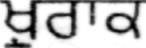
ਖ਼ੁਰਾਕ
